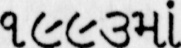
૧૯૯૩માં
